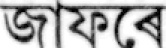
জাফৰে
